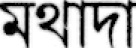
মথাদা
